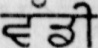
ਵੱਡੀ
